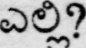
ಎಲ್ಲಿ?
